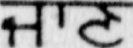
ਜਾਣ
